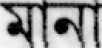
মানা
